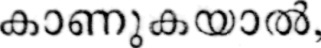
കാണുകയാല്‍,
